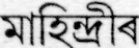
মাহিন্দ্রীৰ
